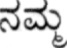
ನಮ್ಮ
